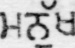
ਮਨੁੱਖ
